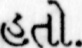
હતો.
